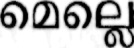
മെല്ലെ
